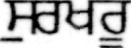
ਸੁਰਖਰੂ
